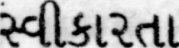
સ્વીકારતા
